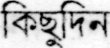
কিছুদিন
